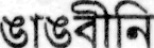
ঙাঙবীনি
